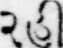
રહી
